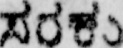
ಸರಕು
